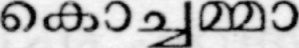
കൊച്ചമ്മാ
